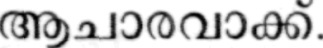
ആചാരവാക്ക്.
